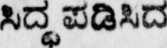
ಸಿದ್ಧಪಡಿಸಿದ
